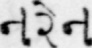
નરેન
